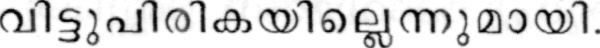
വിട്ടുപിരികയില്ലെന്നുമായി.
